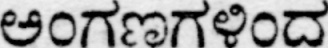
ಅಂಗಣಗಳಿಂದ
